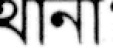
থানা
